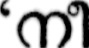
‘നീ
